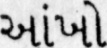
આંખો
